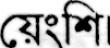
য়েংশি।
